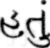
હતું
